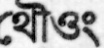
থৌওং
